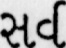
સર્વ
